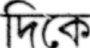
দিকে
